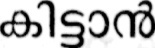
കിട്ടാന്‍
